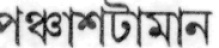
পঞ্চাশটামান
